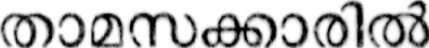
താമസക്കാരില്‍
